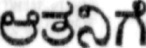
ಆತನಿಗೆ
